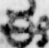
ಈ
